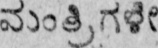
ಮಂತ್ರಿಗಳೇ
